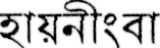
হায়নীংবা
